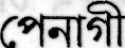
পেনাগী
